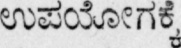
ಉಪಯೋಗಕ್ಕೆ
